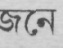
জনে
